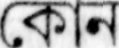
কোন
